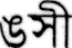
ঙসী
